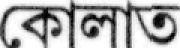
কোলাত
